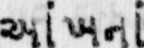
આંખનાં
